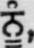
ਨੂੰ,
